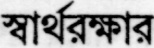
স্বার্থরক্ষার
